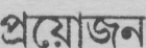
প্ৰয়োজন
